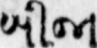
બીજા
